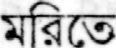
মরিতে
